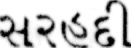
સરહદી
